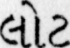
લોટ
